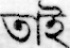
তাই
